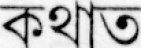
কথাত
